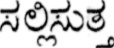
ಸಲ್ಲಿಸುತ್ತ
